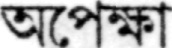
অপেক্ষা
